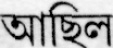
আছিল
